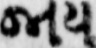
જાય
